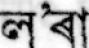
ল'ৰা
